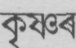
কৃষ্ণৰ
